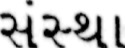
સંસ્થા
